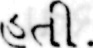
હતી.
